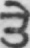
ਤੇ
